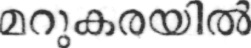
മറുകരയില്‍
